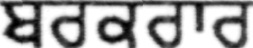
ਬਰਕਰਾਰ
